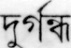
দুর্গন্ধ
